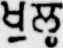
ਖੁਲ੍ਹ
